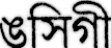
ঙসিগী
